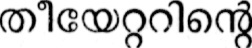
തീയേറ്ററിന്റെ
